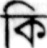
কি
